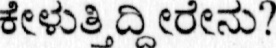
ಕೇಳುತ್ತಿದ್ದೀರೇನು?
